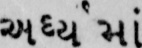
અર્ધ્ય'માં
